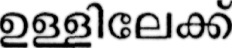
ഉള്ളിലേക്ക്
